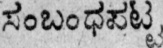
ಸಂಬಂಧಪಟ್ಟ
